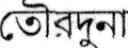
তৌরদুনা
